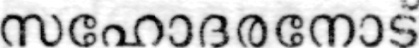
സഹോദരനോട്
